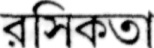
রসিকতা
